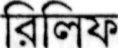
রিলিফ
